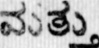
ಮತ್ತು
